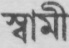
স্বামী
